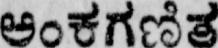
ಅಂಕಗಣಿತ
